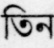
তিন
